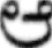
ಆ
